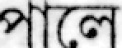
পালে
